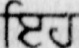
ਇਹ
